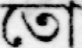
তো
